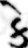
કે
